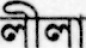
লীলা
